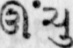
ઊંચુ
